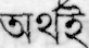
অর্থই
